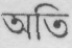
অতি
